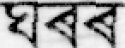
ঘৰৰ
